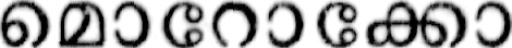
മൊറോക്കോ
